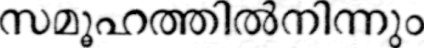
സമൂഹത്തില്‍നിന്നും
